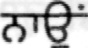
ਨਾਉਂ
